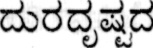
ದುರದೃಷ್ಟದ
